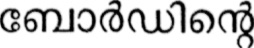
ബോര്‍ഡിന്റെ
